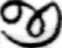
જી
